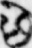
છે
